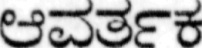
ಆವರ್ತಕ
